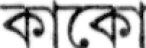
কাকো
